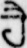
ਹੈ
